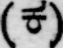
(ಕ)
